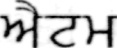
ਐਟਮ
